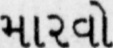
મારવો
